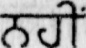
ਨਹੀਂ
